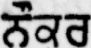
ਨੌਕਰ
